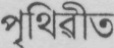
পৃথিৱীত
